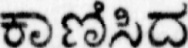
ಕಾಣಿಸಿದ
